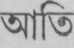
আতি
